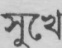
সুখে
